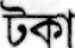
টকা
